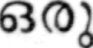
ഒരു
